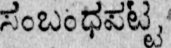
ಸಂಬಂಧಪಟ್ಟ
